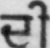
ਦੀ
